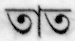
তাত
